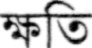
ক্ষতি
